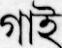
গাই
